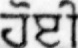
ਹੋਈ
